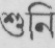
শুনি
